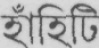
হাঁহিটি
